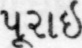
પૂરાઈ
